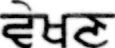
ਵੇਖਣ
